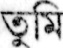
তুমি
